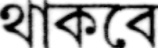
থাকবে
